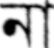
না
